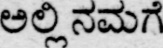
ಅಲ್ಲಿನಮಗೆ
